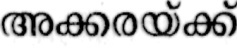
അക്കരയ്ക്ക്
